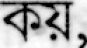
কয়,
